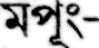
মপূং-
